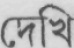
দেখি
